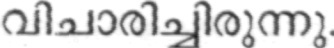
വിചാരിച്ചിരുന്നു.
